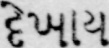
દેખાય
